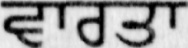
ਵਾਰਤਾ
